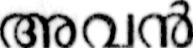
അവന്‍
